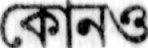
কোনও
